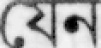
যেন
